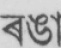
ৰঙা
